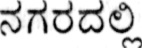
ನಗರದಲ್ಲಿ
